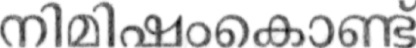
നിമിഷംകൊണ്ട്
